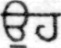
ਉਹ
